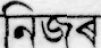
নিজৰ
